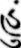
હું
